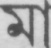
মা
